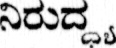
ನಿರುದ್ಧ್ಯ
